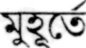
মুহূর্তে
